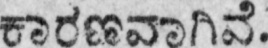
ಕಾರಣವಾಗಿವೆ.
